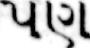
પણ
